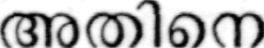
അതിനെ
